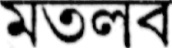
মতলব
